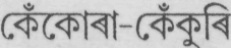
কেঁকোৰা-কেঁকুৰি
